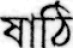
ষাঠি
